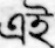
এই
